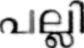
പല്ലി
